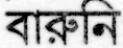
বারুনি
